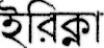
ইরিক্না
